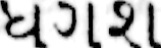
ધગશ
